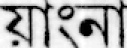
য়াংনা
